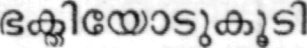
ഭക്തിയോടുകൂടി
